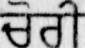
ਚੋਰੀ
